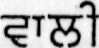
ਵਾਲੀ
